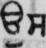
ਉਸ
